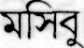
মসিবু
